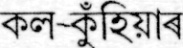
কল-কুঁহিয়াৰ
